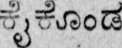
ಕೈಕೊಂಡ
